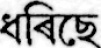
ধৰিছে
